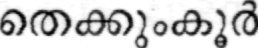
തെക്കുംകൂര്‍
